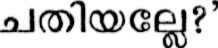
ചതിയല്ലേ?’
